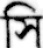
সি
